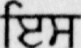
ਇਸ
